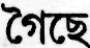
গৈছে
